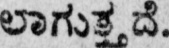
ಲಾಗುತ್ತದೆ.
